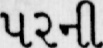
પરની
